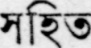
সহিত
